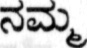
ನಮ್ಮ
